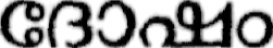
ദോഷം
